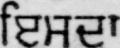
ਇਸਦਾ
